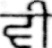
ਵੀ
